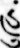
હું
